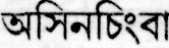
অসিনচিংবা
